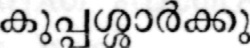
കുപ്പശ്ശാര്‍ക്കു
